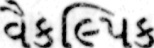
વૈકલ્પિક
